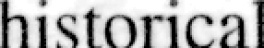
historical
